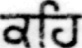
ਕਹਿ
